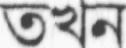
তখন
